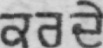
ਕਰਦੇ
